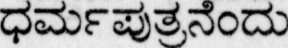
ಧರ್ಮಪುತ್ರನೆಂದು
